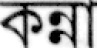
কন্না
